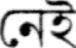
নেই
